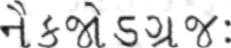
નૈકજોડગ્રજઃ
